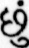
છું
